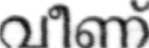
വീണ്
